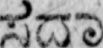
ಸದಾ
